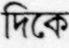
দিকে
